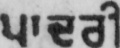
ਪਾਦਰੀ
